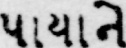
પાયાનો
